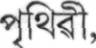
পৃথিৱী,
